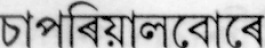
চাপৰিয়ালবোৰে
